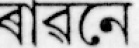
ৰাৱনে
